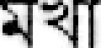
মখা
